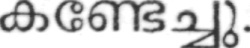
കണ്ടേച്ചു.
